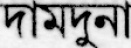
দামদুনা
